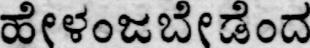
ಹೇಳಂಜಬೇಡೆಂದ
